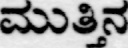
ಮುತ್ತಿನ
